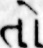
તો
